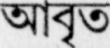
আবৃত
